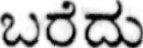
ಬರೆದು
